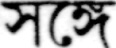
সঙ্গে
